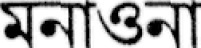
মনাওনা
